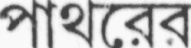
পাথরের
